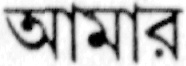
আমার
